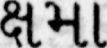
ક્ષમા
